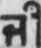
ਜੀ
